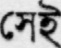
সেই
